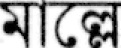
মাল্লে
